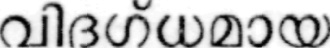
വിദഗ്ധമായ
